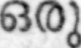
ഒരു
